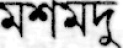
মশমদু
